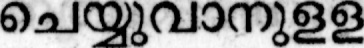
ചെയ്യുവാനുള്ള
